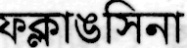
ফক্লাঙসিনা
